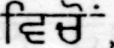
ਵਿਚੋਂ,
